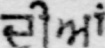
ਦੀਆਂ
